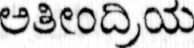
ಅತೀಂದ್ರಿಯ
